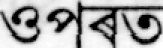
ওপৰত
